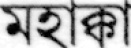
মহাক্কা
